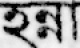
হন্না
